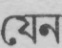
যেন
